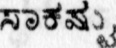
ಸಾಕಷ್ಟು
